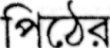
পিঠের
